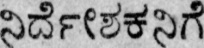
ನಿರ್ದೇಶಕನಿಗೆ
